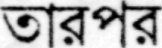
তারপর
